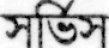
সর্ভিস
